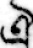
ঐ
